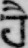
ਹੈ
